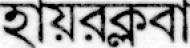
হায়রক্লবা
